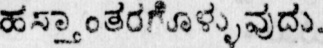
ಹಸ್ತಾಂತರಗೊಳ್ಳುವುದು.
